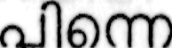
പിന്നെ
